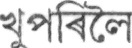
খুপৰিলৈ
